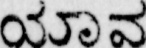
ಯಾವ
